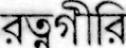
রত্নগীরি
